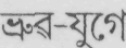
ভ্ৰুৱ-যুগে
